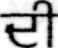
ਦੀ
